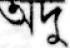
অদু
